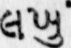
લખું
